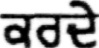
ਕਰਦੇ
